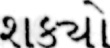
શક્યો
